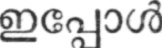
ഇപ്പോള്‍
